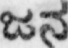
ಜನ
